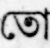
তো
